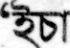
‘ইচা
